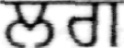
ਲਗ
